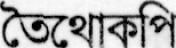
তৈথোকপি
